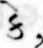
કે,
